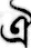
ঐ
